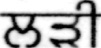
ਲੜੀ
